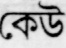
কেউ
